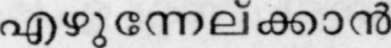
എഴുന്നേല്ക്കാന്‍
